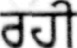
ਰਹੀ
